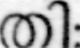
തി:
